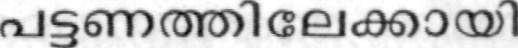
പട്ടണത്തിലേക്കായി
